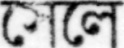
সেলে
